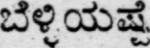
ಬೆಳ್ಳಿಯಷ್ಟೆ
